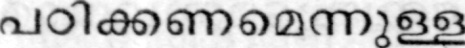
പഠിക്കണമെന്നുള്ള
